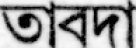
তাবদা
